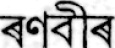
ৰণবীৰ
